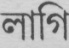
লাগি
